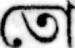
তো
